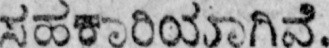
ಸಹಕಾರಿಯಾಗಿವೆ.
